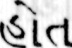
હોત
